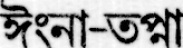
ঈংনা-তপ্না
